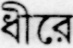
ধীরে
